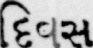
દિવસ
